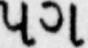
પગ
